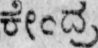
ಕೇಂದ್ರ
